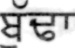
ਬੁੱਢਾ
